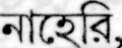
নাহেরি,
